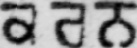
ਕਰਨ
